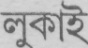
লুকাই
